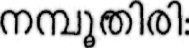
നമ്പൂതിരി:
